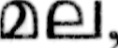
മല,
